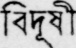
বিদূষী
